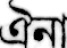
ঐনা
